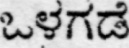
ಒಳಗಡೆ
